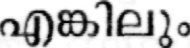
എങ്കിലും
